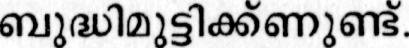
ബുദ്ധിമുട്ടിക്ക്ണുണ്ട്.
